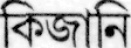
কিজানি
